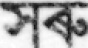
সৰু
